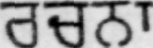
ਰਚਨਾ
